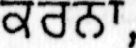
ਕਰਨਾ,
